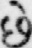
છે
